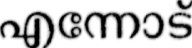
എന്നോട്
